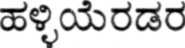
ಹಳ್ಳಿಯೆರಡರ
